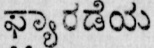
ಫ್ಯಾರಡೆಯ
